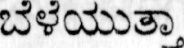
ಬೆಳೆಯುತ್ತಾ
